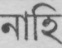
নাহি
